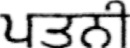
ਪਤਨੀ
